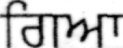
ਗਿਆ
